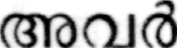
അവര്‍
